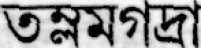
তম্লমগদ্রা
